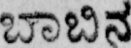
ಬಾಬಿನ
